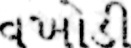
વખોડી
